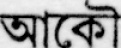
আকৌ
